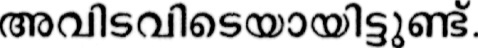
അവിടവിടെയായിട്ടുണ്ട്.
